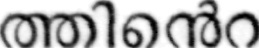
ത്തിന്റെ
